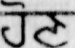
ਹੋਣ
